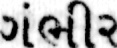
ગંભીર
